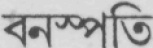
বনস্পতি
